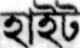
হাইট
